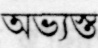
অভ্যস্ত
